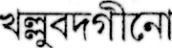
খল্লুবদগীনো
